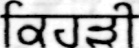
ਕਿਹੜੀ
